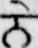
ਨੇ
